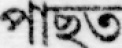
পাছত
